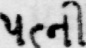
પત્ની
